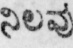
ನಿಲವು
